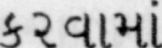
કરવામાં
